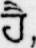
ਹੈ,
